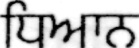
ਧਿਆਨ
